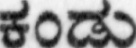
ಕಂಡು
